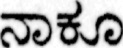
ನಾಕೂ
